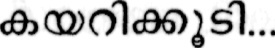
കയറിക്കൂടി...
